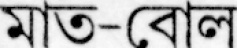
মাত-বোল
